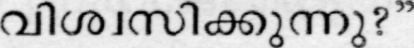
വിശ്വസിക്കുന്നു?"
